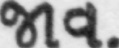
જાવ.
